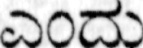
ಎಂದು
